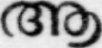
ആ
